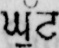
ਘੁੱਟ
